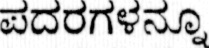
ಪದರಗಳನ್ನೂ
